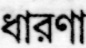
ধারণা
